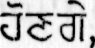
ਹੋਣਗੇ,
